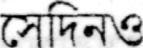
সেদিনও
